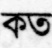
কত
